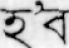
হ'ব
